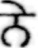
ਨੇ
